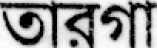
তারগা
